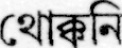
থোক্কনি
